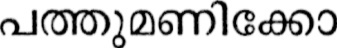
പത്തുമണിക്കോ
